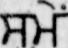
ਸਮੇਂ
